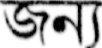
জন্য
